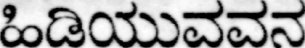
ಹಿಡಿಯುವವನ
